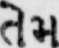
તેમ
